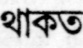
থাকত
